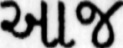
આજ
